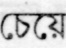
চেয়ে
